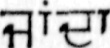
ਜਾਂਦਾ
